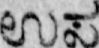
ಉಪ
